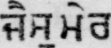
ਜੈਸੁਮੇਰ
